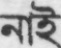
নাই
